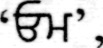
'ਓਮ',
